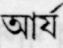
আর্য
